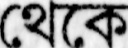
থেকে
